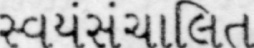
સ્વયંસંચાલિત
